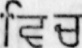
ਵਿਚ
